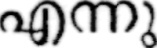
എന്നു
